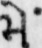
મેં
